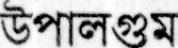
উপালগুম
